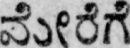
ಮೇರೆಗೆ
